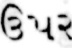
ઉપર
